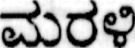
ಮರಳಿ
